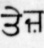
ਤੇਜ਼
